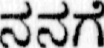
ನನಗೆ
